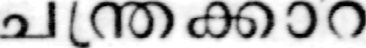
ചന്ത്രക്കാറ
